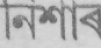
নিশাৰ
